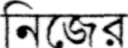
নিজের
